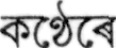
কণ্ঠেৰে
